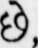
છે,
